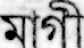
মাগী
